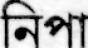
নিপা
